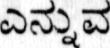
ಎನ್ನುವ
